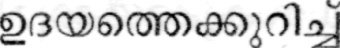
ഉദയത്തെക്കുറിച്ച്
